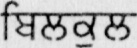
ਬਿਲਕੁਲ
